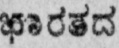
ಭಾರತದ
